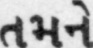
તમને
